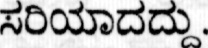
ಸರಿಯಾದದ್ದು.
